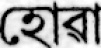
হোৱা
